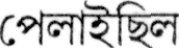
পেলাইছিল
